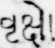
વૃક્ષો
